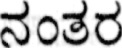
ನಂತರ
